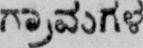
ಗ್ರಾಮಗಳ
